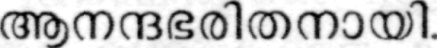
ആനന്ദഭരിതനായി.
